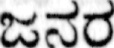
ಜನರ
